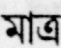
মাত্র
